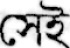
সেই
